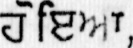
ਹੋਇਆ,
